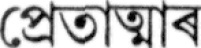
প্রেতাত্মাৰ
